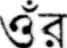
ওঁর
